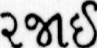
રજાઈ
